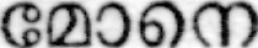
മോനെ
